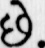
છે.
